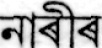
নাৰীৰ
